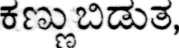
ಕಣ್ಣುಬಿಡುತ,
